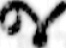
જ
